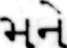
મને
